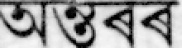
অন্তৰৰ
